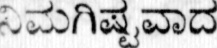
ನಿಮಗಿಷ್ಟವಾದ
